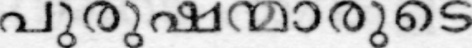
പുരുഷന്മാരുടെ
